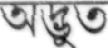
অদ্ভুত
